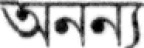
অনন্য
